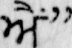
ਐਂ''
